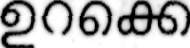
ഉറക്കെ
